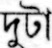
দুটা
